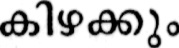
കിഴക്കും
